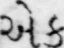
એક
